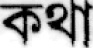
কথা
